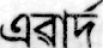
এৱার্দ
